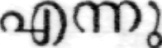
എന്നു
